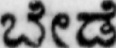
ಬೇಡೆ
